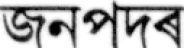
জনপদৰ
